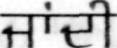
ਜਾਂਦੀ
